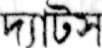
দ্যাটস
